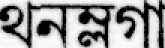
থনম্লগা
